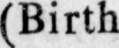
(Birth
